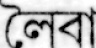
লৈবা
